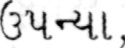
ઉપન્યા,
